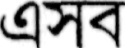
এসব
